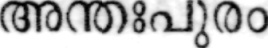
അന്തഃപുരം
